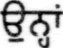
ਉਨ੍ਹਾਂ
